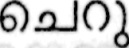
ചെറു
